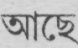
আছে
